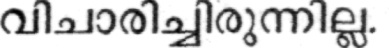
വിചാരിച്ചിരുന്നില്ല.
